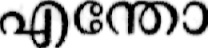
എന്തോ
